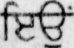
ਇਉਂ
